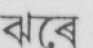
ঝৰে
